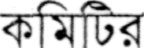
কমিটির
